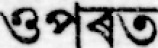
ওপৰত
